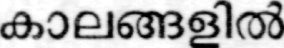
കാലങ്ങളില്‍
